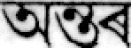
অন্তৰ
